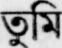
তুমি
